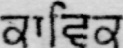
ਕਾਵਿਕ
